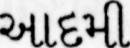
આદમી
